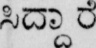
ಸಿದ್ದಾರೆ
